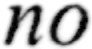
no
